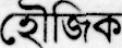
হৌজিক
